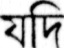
যদি
